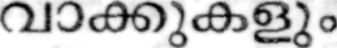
വാക്കുകളും
